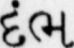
દંભ
